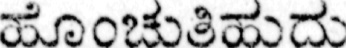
ಹೊಂಚುತಿಹುದು
